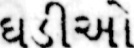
ઘડીઓ
